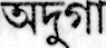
অদুগা
